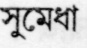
সুমেধা
